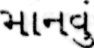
માનવું
